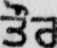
ਤੌਰ
